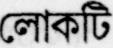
লোকটি
